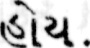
હોય.
